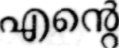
എന്റെ
